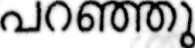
പറഞ്ഞു
